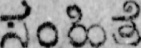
ಸಂಹಿತೆ
